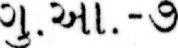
ગુ.આ.-૭
